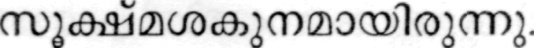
സൂക്ഷ്മശകുനമായിരുന്നു.
